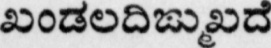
ಖಂಡಲದಿಙ್ಮುಖದೆ
